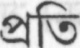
প্রতি
